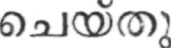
ചെയ്തു
